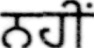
ਨਹੀਂ
